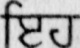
ਇਹ
